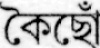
কৈছোঁ
